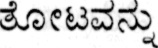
ತೋಟವನ್ನು
